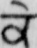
ਕੇ
